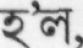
হ'ল,
